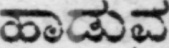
ಹಾಡುವ
